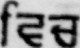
ਵਿਚ
